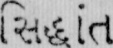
સિદ્ધાંત
